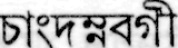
চাংদম্নবগী
